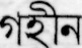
গহীন
